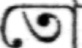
তো
